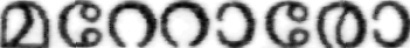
മറ്റോരോ
